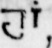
ਹਾਂ,
